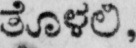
ತೊಳಲಿ,
